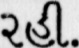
રહી.
